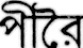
পীরৈ
